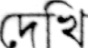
দেখি
